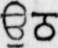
ਉਠ
